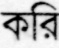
করি
